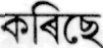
কৰিছে
